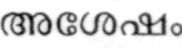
അശേഷം
